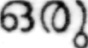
ഒരു
